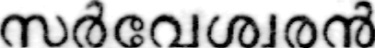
സര്‍വേശ്വരന്‍
